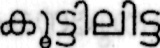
കൂട്ടിലിട്ട
